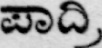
ಪಾದ್ರಿ
